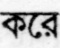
করে
